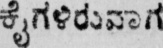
ಕೈಗಳಿರುವಾಗ
